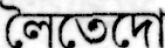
লৈতেদো
